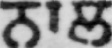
ਨਾਲ
